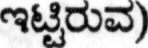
ಇಟ್ಟಿರುವ)
